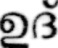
ഉദ്
